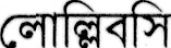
লোল্লিবসি
